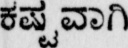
ಕಷ್ಟವಾಗಿ
